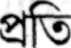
প্রতি
